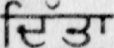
ਦਿੱਤਾ
